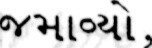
જમાવ્યો,
